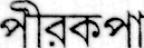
পীরকপা
